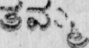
ತಮ್ಮ
